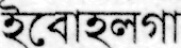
ইবোহলগা
